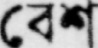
বেশ
